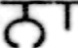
ਨਾ
